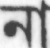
না
